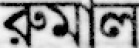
রুমাল
